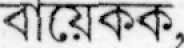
বায়েকক,
